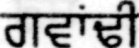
ਗਵਾਂਢੀ
